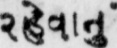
રહેવાનું
